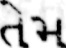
તેમ
